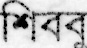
শিববু
